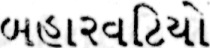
બહારવટિયો
